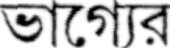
ভাগ্যের
